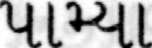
પામ્યા
